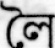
লৈ
